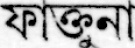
ফাক্তুনা
